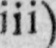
iii)
